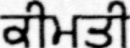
ਕੀਮਤੀ
